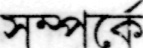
সম্পর্কে
